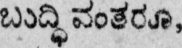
ಬುದ್ಧಿವಂತರೂ,
